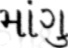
માંગુ
